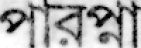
পারপ্না
